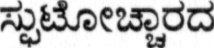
ಸ್ಫುಟೋಚ್ಚಾರದ
